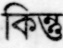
কিন্তু
